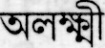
অলক্ষ্মী
